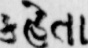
કહેતા
